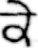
ਕੇ
